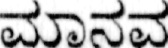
ಮಾನವ
